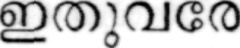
ഇതുവരേ
